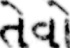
તેવો
